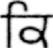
ਕਿ
